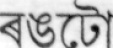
ৰঙটো
